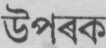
উপৰক
